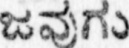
ಜವುಗು
